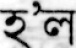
হ'ল
